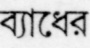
ব্যাধের
